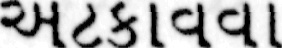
અટકાવવા
